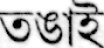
তঙাই
